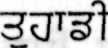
ਤੁਹਾਡੀ
